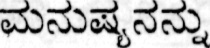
ಮನುಷ್ಯನನ್ನು
